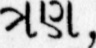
ત્રણ,
